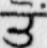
ਤੋਂ
